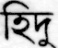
হিদু
